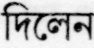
দিলেন
